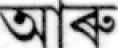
আৰু
